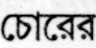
চোরের
